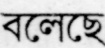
বলেছে
